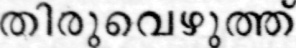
തിരുവെഴുത്ത്
